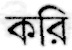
করি
